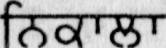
ਨਿਕਾਲਾ
